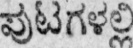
ಪುಟಗಳಲ್ಲಿ
